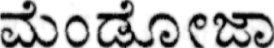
ಮೆಂಡೋಜಾ
